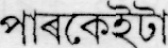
পাৰকেইটা
